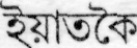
ইয়াতকৈ
